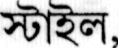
স্টাইল,
